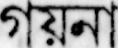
গয়না
